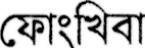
ফোংখিবা
